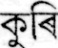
কুৰি
